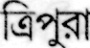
ত্রিপুরা
